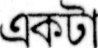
একটা
